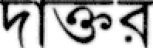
দাক্তর
